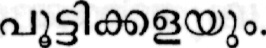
പൂട്ടിക്കളയും.
